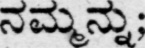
ನಮ್ಮನ್ನು;
